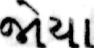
જોયા
